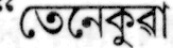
"তেনেকুৱা
